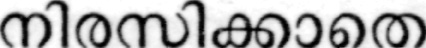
നിരസിക്കാതെ
